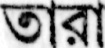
তারা
